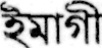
ইমাগী
